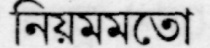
নিয়মমতো
